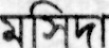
মসিদা
